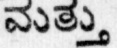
ಮತ್ತು
